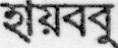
হায়ববু
